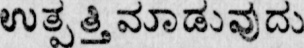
ಉತ್ಪತ್ತಿಮಾಡುವುದು
